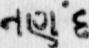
નણંદ
